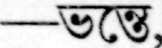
–ভন্তে,
